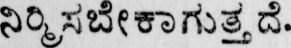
ನಿರ್‍ಮಿಸಬೇಕಾಗುತ್ತದೆ.
